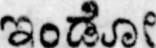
ಇಂಡೋ
